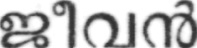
ജീവന്‍
